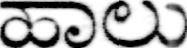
ಹಾಲು
